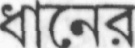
ধানের
